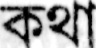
কথা
